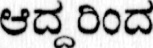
ಆದ್ದರಿಂದ
